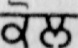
ਕੋਲ
